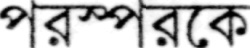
পরস্পরকে
